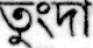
তুংদা
